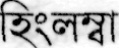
হিংলম্বা
